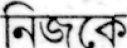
নিজকে
